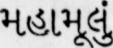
મહામૂલું
